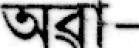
অৱা-
